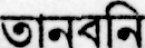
তানবনি
